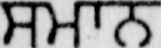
ਸਮਾਨ
